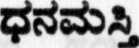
ಧನಮಸ್ತಿ
